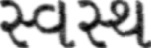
સ્વસ્થ
